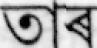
তাৰ
